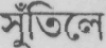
সুঁতিলে
